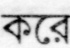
করে
